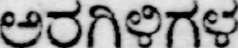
ಅರಗಿಳಿಗಳ
